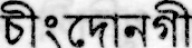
চীংদোনগী
